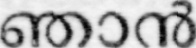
ഞാന്‍
